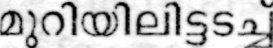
മുറിയിലിട്ടടച്ച്
